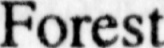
Forest
